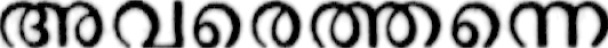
അവരെത്തന്നെ
